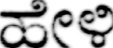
ಹೇಳಿ
